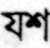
যশ
